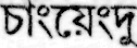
চাংয়েংদু
